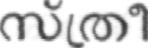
സ്ത്രീ
